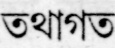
তথাগত
